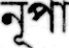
নূপা
